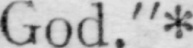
God"*
